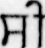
ਸੀ
